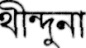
থীন্দুনা
